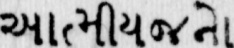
આત્મીયજનો
